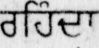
ਰਹਿੰਦਾ
